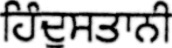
ਹਿੰਦੁਸਤਾਨੀ
